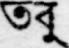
তবু
